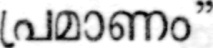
പ്രമാണം”
